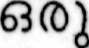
ഒരു
